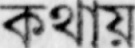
কথায়
